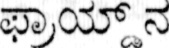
ಫ್ರಾಯ್ಡ್ನ
